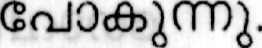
പോകുന്നു.
